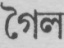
গৈল
